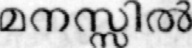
മനസ്സില്‍
